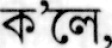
ক'লে,
